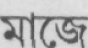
মাজে
